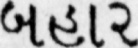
બહાર
